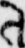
તે
